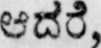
ಆದರೆ,
